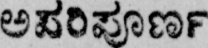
ಅಪರಿಪೂರ್ಣ
